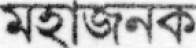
মহাজনক
